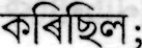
কৰিছিল;
